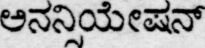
ಅನನ್ಸಿಯೇಷನ್
